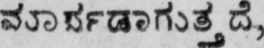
ಮಾರ್ಪಾಡಾಗುತ್ತದೆ
